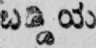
ಬಡ್ಡಿಯ
